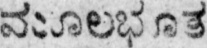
ಮೂಲಭೂತ
